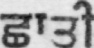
ਛਾਤੀ
